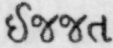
ઈજજત
